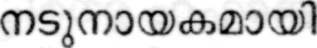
നടുനായകമായി
